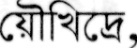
য়ৌখিদ্রে,
